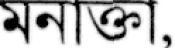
মনাক্তা,
